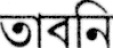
তাবনি
